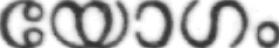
യോഗം
